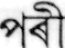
পৰী
